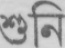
শুনি
